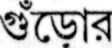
গুঁড়োর
